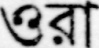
ওরা
